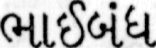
ભાઈબંધ
